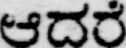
ಆದರೆ
